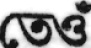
তেওঁ
